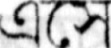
এসে
